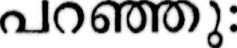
പറഞ്ഞു:
